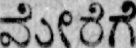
ಮೇರೆಗೆ
